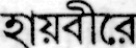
হায়বীরে
